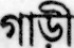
গাড়ী
